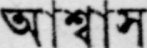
আশ্বাস
